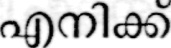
എനിക്ക്
